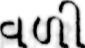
વળી
